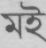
মই
